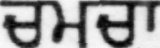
ਚਮਚਾ
